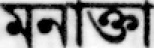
মনাক্তা
